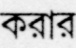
করার
